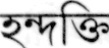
হন্দক্তি
